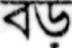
বড়
